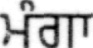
ਮੰਗਾ
